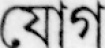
যোগ
